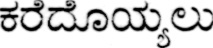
ಕರೆದೊಯ್ಯಲು
